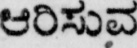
ಆರಿಸುವ
